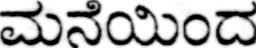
ಮನೆಯಿಂದ
